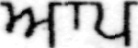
ਆਪ
